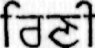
ਰਿਣੀ
